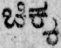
ಚಿಕ್ಕ
